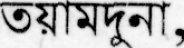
তয়ামদুনা,
